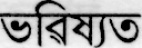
ভৱিষ্যত
